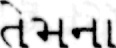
તેમના
